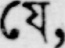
যে,
